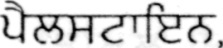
ਪੈਲਸਟਾਇਨ,
